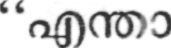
"എന്താ
